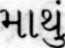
માથું
